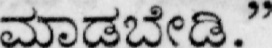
ಮಾಡಬೇಡಿ."
